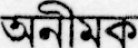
অনীমক
